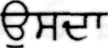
ਉਸਦਾ
